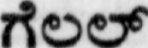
ಗೆಲಲ್
